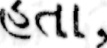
હતા,
